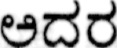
ಅದರ
